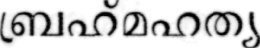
ബ്രഹ്മഹത്യ
